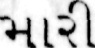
મારી
